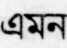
এমন
